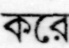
করে
